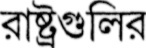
রাষ্ট্রগুলির
